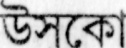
উসকো
